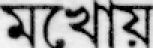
মখোয়
